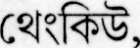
থেংকিউ,
